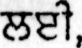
ਲਈ,
